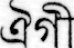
ঐগী
